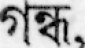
গন্ধ,
